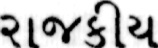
રાજકીય
